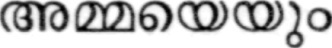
അമ്മയെയും
